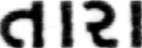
તારા
